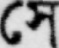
সে
